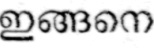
ഇങ്ങനെ
